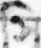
সি
